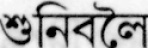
শুনিবলৈ
